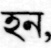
হন,
